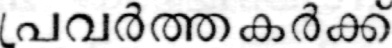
പ്രവര്‍ത്തകര്‍ക്ക്
